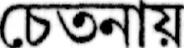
চেতনায়
